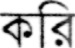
করি
